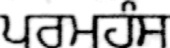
ਪਰਮਹੰਸ
